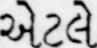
એટલે
